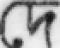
দে
